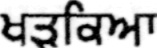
ਖੜਕਿਆ
